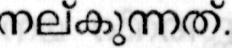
നല്കുന്നത്.
